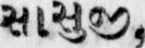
સાસુજી,
